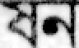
ষন
